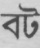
বট
